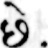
છે.
